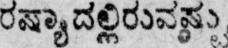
ರಷ್ಯಾದಲ್ಲಿರುವಷ್ಟು
